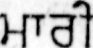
ਮਾਰੀ
